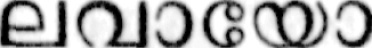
ലവായോ
